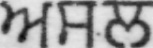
ਅਸਲ
